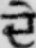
ਦੇ
